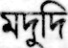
মদুদি
